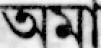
অমা
